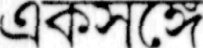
একসঙ্গে
